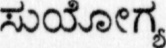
ಸುಯೋಗ್ಯ
